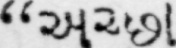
"અચ્છા
